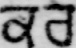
ਕਰ
